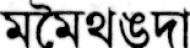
মমৈথঙদা
